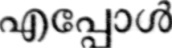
എപ്പോള്‍
